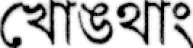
খোঙথাং
